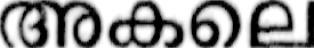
അകലെ
